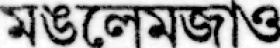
মঙলেমজাও
